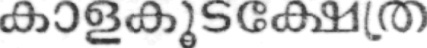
കാളകൂടക്ഷേത്ര
